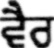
ਵੈਰ
